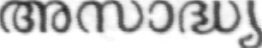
അസാദ്ധ്യ
